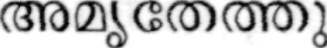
അമൃതേത്തു
